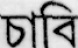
চাবি
